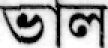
ভাল
